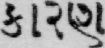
કારણ
